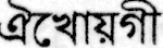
ঐখোয়গী
